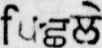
ਪਿਛਲੇ
